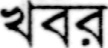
খবর
